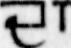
ਦਾ
